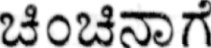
ಚಿಂಚಿನಾಗೆ
